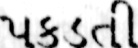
પકડતી
